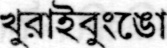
খুরাইবুংঙো
